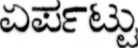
ಏರ್ಪಟ್ಟು
